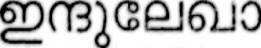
ഇന്ദുലേഖാ
